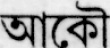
আকৌ
